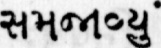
સમજાવ્યું
